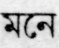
মনে
